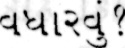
વધારવું?
